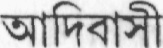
আদিবাসী
